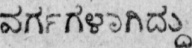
ವರ್ಗಗಳಾಗಿದ್ದು
